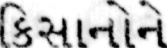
કિસાનોને
